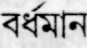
বর্ধমান
